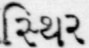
સ્થિર
